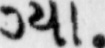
ગ્યા.
